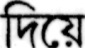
দিয়ে
